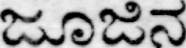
ಜೂಜಿನ
